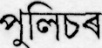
পুলিচৰ
